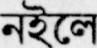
নইলে
